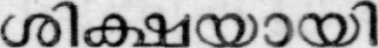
ശിക്ഷയായി
